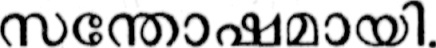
സന്തോഷമായി.
